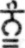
ਨੂੰ
